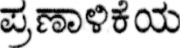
ಪ್ರಣಾಳಿಕೆಯ
